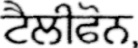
ਟੈਲੀਫੋਨ,
